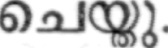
ചെയ്തു.
